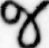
જ
